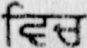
ਵਿਚ
